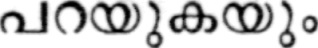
പറയുകയും
